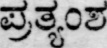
ಪ್ರತ್ಯಂಶ
